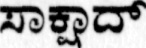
ಸಾಕ್ಷಾದ್
